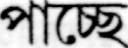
পাচ্ছে
